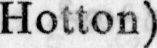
Hotton)
